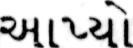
આપ્યો
